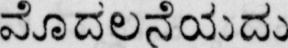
ಮೊದಲನೆಯದು
